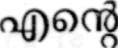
എന്റെ
